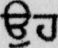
ਉਹ
